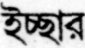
ইচ্ছার
